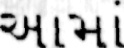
આમાં
